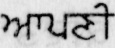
ਆਪਣੀ
